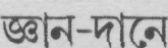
জ্ঞান-দানে
